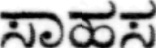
ಸಾಹಸ
